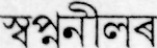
স্বপ্ননীলৰ
